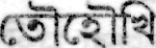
তৌহৌখি
